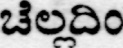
ಚೆಲ್ಲದಿಂ
